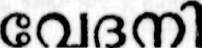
വേദനി
